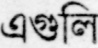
এগুলি
